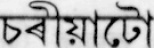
চৰীয়াটো
